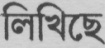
লিখিছে
